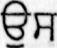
ਉਸ
